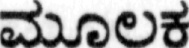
ಮೂಲಕ
